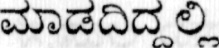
ಮಾಡದಿದ್ದಲ್ಲಿ
